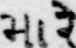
મારે
